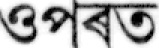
ওপৰত
